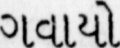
ગવાયો
